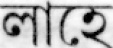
লাহে
